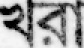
খরা
